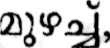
മുഴച്ച്,
